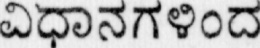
ವಿಧಾನಗಳಿಂದ
